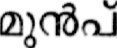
മുന്‍പ്
